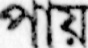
পায়
